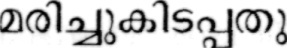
മരിച്ചുകിടപ്പതു
